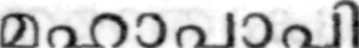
മഹാപാപി
